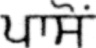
ਪਾਸੋਂ
